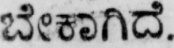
ಬೇಕಾಗಿದೆ.
